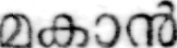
മകാന്‍
